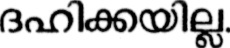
ദഹിക്കയില്ല.
